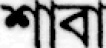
শাবা
